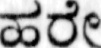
ಹರೇ
